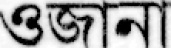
ওজানা
